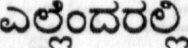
ಎಲ್ಲೆಂದರಲ್ಲಿ
